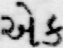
એક
